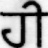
ਹੀ
